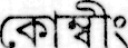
কোম্বীং
